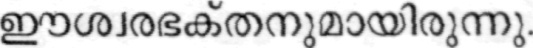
ഈശ്വരഭക്തനുമായിരുന്നു.
